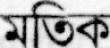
মতিক
